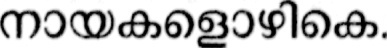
നായകളൊഴികെ.
